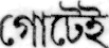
গোটেই
